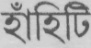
হাঁহিটি
